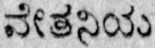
ವೇತನಿಯ
